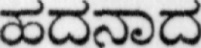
ಹದನಾದ
